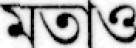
মতাও
